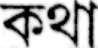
কথা
